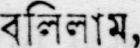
বলিলাম,
